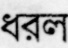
ধরল
